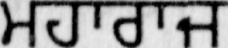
ਮਹਾਰਾਜ
